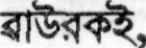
ৱাউরকই,
